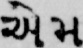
એમ
